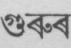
গুৰুৰ
